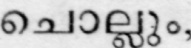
ചൊല്ലും,
